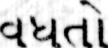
વધતો
